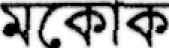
মকোক
